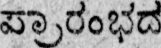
ಪ್ರಾರಂಭದ
